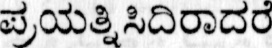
ಪ್ರಯತ್ನಿಸಿದಿರಾದರೆ
